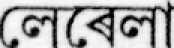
লেৰেলা
